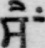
ਸੈਂ
